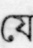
যে
